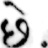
છે.
